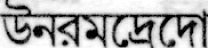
উনরমদ্রেদো
